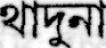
থাদুনা
